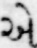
એ
